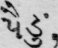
પૈડું,
